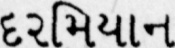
દરમિયાન
